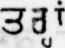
ਤਰ੍ਹਾਂ
